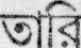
তারি
